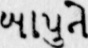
બાપુને
